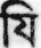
যি
